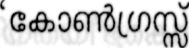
'കോണ്‍ഗ്രസ്സ്
